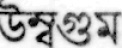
উম্বগুম
